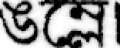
ঙম্লে।
